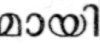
മായി
